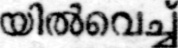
യില്‍വെച്ച്
